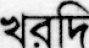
খরদি
